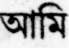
আমি
